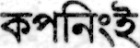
কপনিংই
